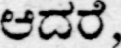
ಆದರೆ,
